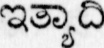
ಇತ್ಯಾದಿ
